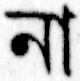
না
